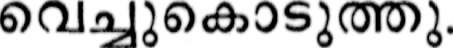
വെച്ചുകൊടുത്തു.
